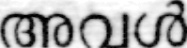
അവള്‍
